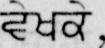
ਵੇਖਕੇ,
